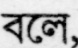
বলে,
